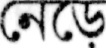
নেড়ে
